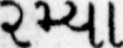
રમ્યા
